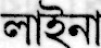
লাইনা
